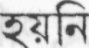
হয়নি
